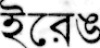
ইরেঙ
